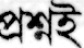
প্রশ্নই
